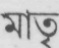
মাতৃ
